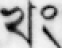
খং
